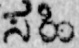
ಸಹಿ
